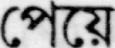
পেয়ে
